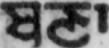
ਬਣਾ
